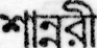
শান্নরী
